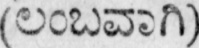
(ಲಂಬವಾಗಿ)
